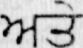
ਅਤੇ
